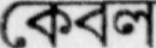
কেবল
